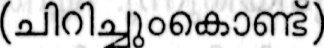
(ചിറിച്ചുംകൊണ്ട്)
